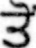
ਤੋਂ
